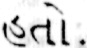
હતો.
